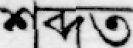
শব্দত
